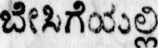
ಬೇಸಿಗೆಯಲ್ಲಿ
